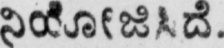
ನಿಯೋಜಿಸಿದೆ.
